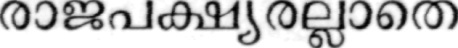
രാജപക്ഷ്യരല്ലാതെ
